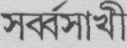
সৰ্ব্বসাখী
